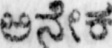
ಅನೇಕ
